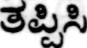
ತಪ್ಪಿಸಿ
